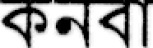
কনবা
